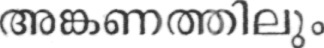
അങ്കണത്തിലും
